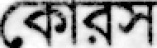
কোরস
